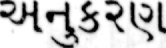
અનુકરણ
